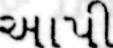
આપી
